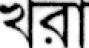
খরা
